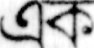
এক
